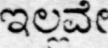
ಇಲ್ಲವೇ
